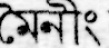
মৈনীং
